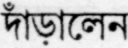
দাঁড়ালেন
